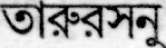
তারুরসনু
